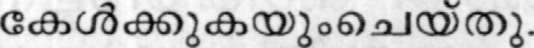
കേള്‍ക്കുകയുംചെയ്തു.
